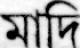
মাদি
